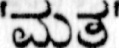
‘ಮತ’
